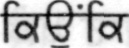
ਕਿਉਂਕਿ
